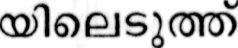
യിലെടുത്ത്
